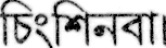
চিংশিনবা।
